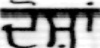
ਦੋਸ਼ਾਂ
